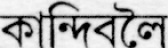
কান্দিবলৈ
